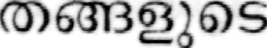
തങ്ങളുടെ
